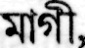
মাগী,
